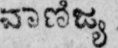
ವಾಣಿಜ್ಯ
